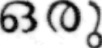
ഒരു
